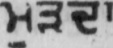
ਮੁੜਦਾ
